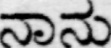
ನಾನು
